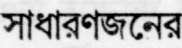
সাধারণজনের
